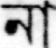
না
